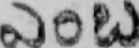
ಎಂಬ
